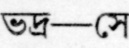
ভদ্র–সে
